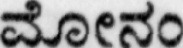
ಮೋನಂ
